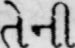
તેની
